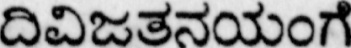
ದಿವಿಜತನಯಂಗೆ
